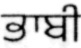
ਭਾਬੀ
